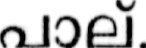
പാല്.
